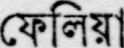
ফেলিয়া
